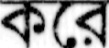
করে
